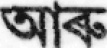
আৰু
